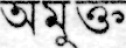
অমুক্ত
